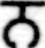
ਨ
